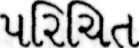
પરિચિત
